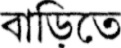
বাড়িতে
